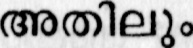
അതിലും
